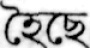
হৈছে
